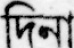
দিনা
